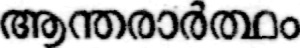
ആന്തരാര്‍ത്ഥം
